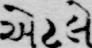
એટલે
